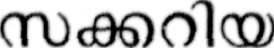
സക്കറിയ
